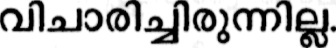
വിചാരിച്ചിരുന്നില്ല.
